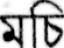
মচি
